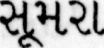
સૂમરા
